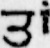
ਤਾਂ
